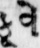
કૂવે
